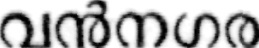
വന്‍നഗര
